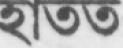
হাতত
